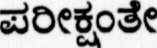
ಪರೀಕ್ಷಂತೇ
